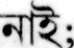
নাই;
